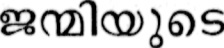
ജന്മിയുടെ
